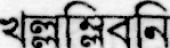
খল্লম্লিবনি
